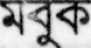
মবুক
